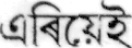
এৰিয়েই
